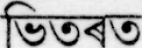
ভিতৰত
